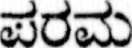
ಪರಮ
